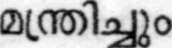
മന്ത്രിച്ചും
